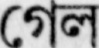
গেল
